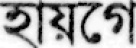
হায়গে
